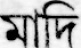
মাদি
